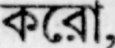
করো,
